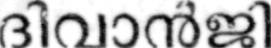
ദിവാന്‍ജി
